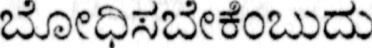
ಬೋಧಿಸಬೇಕೆಂಬುದು
